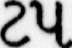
ટપ
